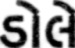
ડોલે
